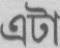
এটা
